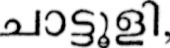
ചാട്ടൂളി,
